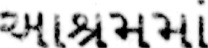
આશ્રમમાં
